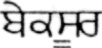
ਬੇਕਸੂਰ
